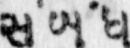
સંબંધ
